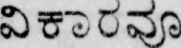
ವಿಕಾರವೂ
